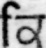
ਕਿ
